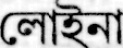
লোইনা
